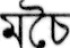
মচৈ
